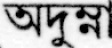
অদুম্না
